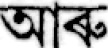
আৰু
